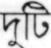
দুটি
